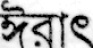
ঈরাৎ
